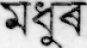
মধুৰ
